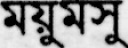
ময়ুমসু
